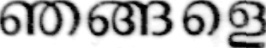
ഞങ്ങളെ
